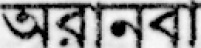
অরানবা
